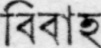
বিবাহ
